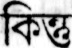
কিন্তু
